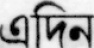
এদিন
